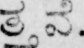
ತ್ತವೆ.
